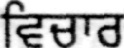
ਵਿਚਾਰ
